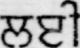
ਲਈ
